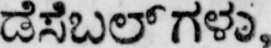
ಡೆಸೆಬಲ್‌ಗಳು,
